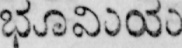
ಭೂಮಿಯ
